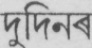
দুদিনৰ
